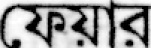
ফেয়ার
